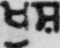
ਖੁਸ਼
